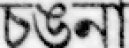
চঙনা
